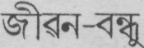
জীৱন-বন্ধু
